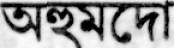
অহুমদো
